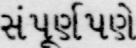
સંપૂર્ણપણે
